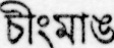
চীংমাঙ
